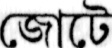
জোটে
